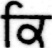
ਕਿ
